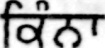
ਕਿੰਨਾ
